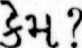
કેમ?
